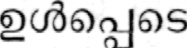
ഉള്‍പ്പെടെ
